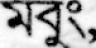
মবুং,
